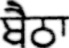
ਬੈਠਾ
